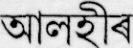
আলহীৰ
